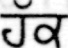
ਹੱਕ
